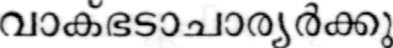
വാക്ഭടാചാര്യര്‍ക്കു
